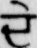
ਦੇ
